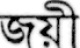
জয়ী
